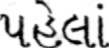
પહેલાં
